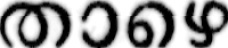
താഴെ
